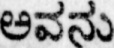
ಅವನು
